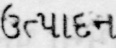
ઉત્પાદન
